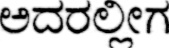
ಅದರಲ್ಲೀಗ
